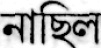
নাছিল
